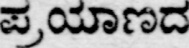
ಪ್ರಯಾಣದ
